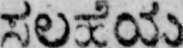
ಸಲಹೆಯ
